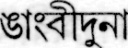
ঙাংবীদুনা
